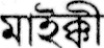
মাইক্কী
